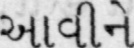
આવીને
